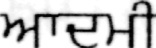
ਆਦਮੀ
